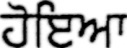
ਹੋਇਆ
